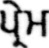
ਪ੍ਰੇਮ
